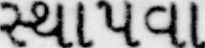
સ્થાપવા
